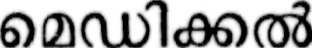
മെഡിക്കല്‍
